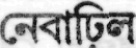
নেবাঢ়িল
